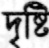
দৃষ্টি
